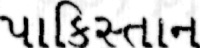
પાકિસ્તાન
